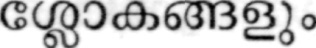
ശ്ലോകങ്ങളും
